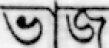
ভাজ
